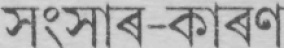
সংসাৰ-কাৰণ
